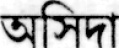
অসিদা
